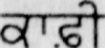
ਕਾਫ਼ੀ
